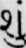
શું
